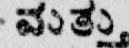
ಮತ್ತು
